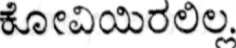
ಕೋವಿಯಿರಲಿಲ್ಲ.
